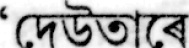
'দেউতাৰে
